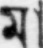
মা
